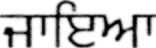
ਜਾਇਆ
